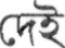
দেই
